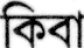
কিবা
